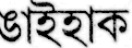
ঙাইহাক
